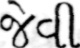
જેવી
